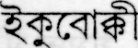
ইকুবোক্কী
